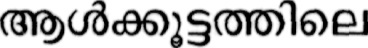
ആള്‍ക്കൂട്ടത്തിലെ
